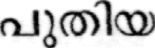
പുതിയ
